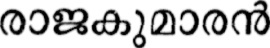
രാജകുമാരന്‍
